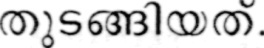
തുടങ്ങിയത്.
